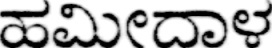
ಹಮೀದಾಳ
